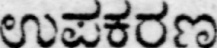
ಉಪಕರಣ
